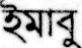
ইমাবু
